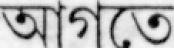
আগতে
